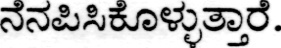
ನೆನಪಿಸಿಕೊಳ್ಳುತ್ತಾರೆ.
